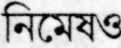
নিমেষও
